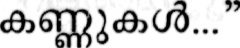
കണ്ണുകള്‍...”
